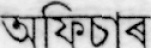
অফিচাৰ
